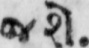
જશે.
